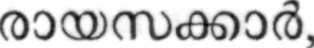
രായസക്കാര്‍,
